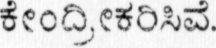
ಕೇಂದ್ರೀಕರಿಸಿವೆ.
